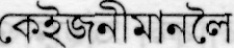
কেইজনীমানলৈ
